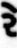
રે
